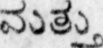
ಮತ್ತು
